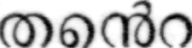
തന്റെ
